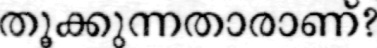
തൂക്കുന്നതാരാണ്?
